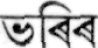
ভৰিৰ
